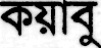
কয়াবু
